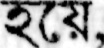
হয়ে,
